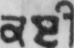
ਕਈ
